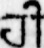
ਹੀ
